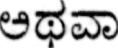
ಅಥವಾ
